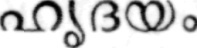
ഹൃദയം
